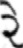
રે
